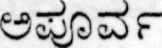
ಅಪೂರ್ವ
